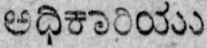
ಅಧಿಕಾರಿಯು
